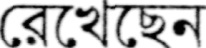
রেখেছেন
